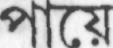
পায়ে
